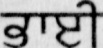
ਭਾਈ
